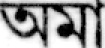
অমা
